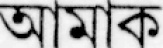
আমাক
